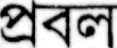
প্রবল
